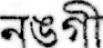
নঙগী
